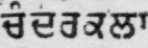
ਚੰਦਰਕਲਾ
